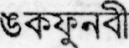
ঙকফুনবী
